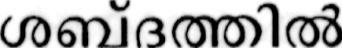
ശബ്ദത്തില്‍
